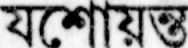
যশোয়ন্ত
